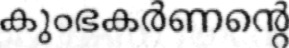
കുംഭകര്‍ണന്റെ
